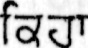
ਕਿਹਾ
